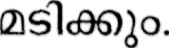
മടിക്കും.
